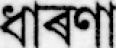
ধাৰণা
